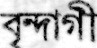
বৃন্দাগী
